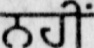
ਨਹੀਂ
